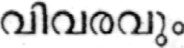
വിവരവും
